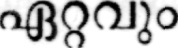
ഏറ്റവും
